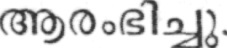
ആരംഭിച്ചു.
